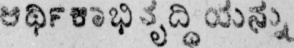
ಆರ್ಥಿಕಾಭಿವೃದ್ಧಿಯನ್ನು
